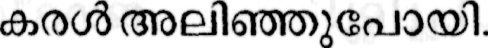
കരള്‍അലിഞ്ഞുപോയി.
